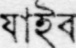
যাইব
